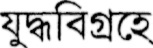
যুদ্ধবিগ্রহে
